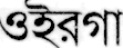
ওইরগা
